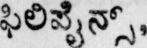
ಫಿಲಿಪೈನ್ಸ್,
